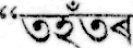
"তহঁতৰ
